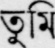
তুমি
